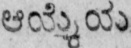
ಆಯ್ಕೆಯ
